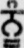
ਨੂੰ
